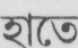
হাতে
